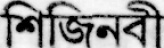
শিজিনবী
